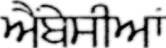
ਐਂਬੇਸੀਆਂ
